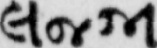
લજજા
